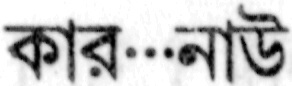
কার...নাউ
